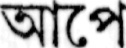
আপে
